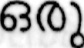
ഒരു
